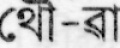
থৌ-ৱা
